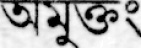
অমুক্তং
